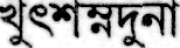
খুৎশম্নদুনা
